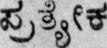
ಪ್ರತ್ಯೇಕ
